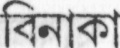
বিনাকা
